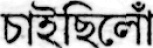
চাইছিলোঁ
